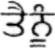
ਤੈਨੂੰ
